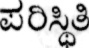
ಪರಿಸ್ಥಿತಿ
